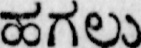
ಹಗಲು
